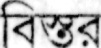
বিস্তর
